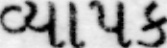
વ્યાપક
